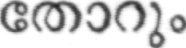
തോറും
